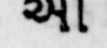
'આ
